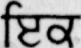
ਇਕ
